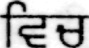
ਵਿਚ
